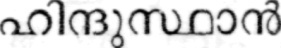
ഹിന്ദുസ്ഥാന്‍
